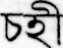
চহী
